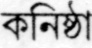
কনিষ্ঠা
